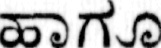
ಹಾಗೂ
